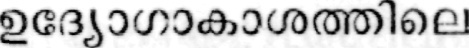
ഉദ്യോഗാകാശത്തിലെ
